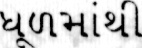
ધૂળમાંથી
